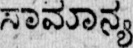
ಸಾಮಾನ್ಯ
